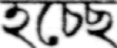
হচ্ছে
